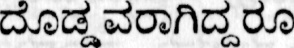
ದೊಡ್ಡವರಾಗಿದ್ದರೂ
